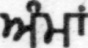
ਅੰਮਾਂ
